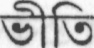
ভীতি
